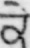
ਕੇ
